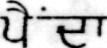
ਪੈਂਦਾ
